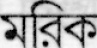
মরিক
